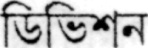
ডিভিশন
